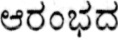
ಆರಂಭದ
